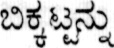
ಬಿಕ್ಕಟ್ಟನ್ನು
